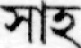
সাহ
